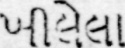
ખીલેલા
